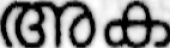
അക
